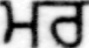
ਮਰ
